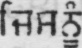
ਜਿਸਨੂੰ
